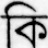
কি
